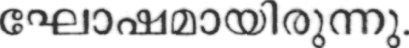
ഘോഷമായിരുന്നു.
